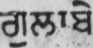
ਗੁਲਾਬੇ
